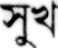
সুখ
